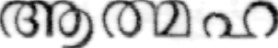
ആത്മഹ
